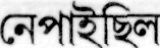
নেপাইছিল
